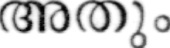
അതും
